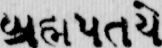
બ્રહ્મપતયે
